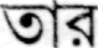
তার
